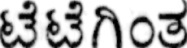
ಟೆಟೆಗಿಂತ
